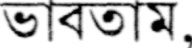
ভাবতাম,
